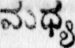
ಮಧ್ಯ
